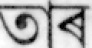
তাৰ
